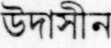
উদাসীন
